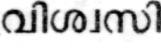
വിശ്വസി
